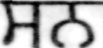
ਸਨ
